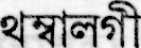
থম্বালগী
